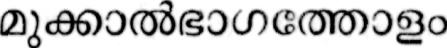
മുക്കാല്‍ഭാഗത്തോളം
